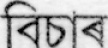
বিচাৰ
